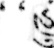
"હું
